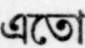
এতো
